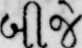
બીજે
